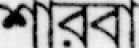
শারবা
